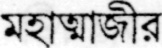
মহাত্মাজীর
